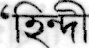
‘হিন্দী
